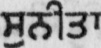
ਸੁਨੀਤਾ
